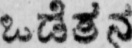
ಒಡೆತನ
